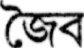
জৈব
